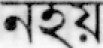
নহয়
